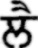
ਲੈ
